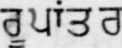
ਰੂਪਾਤਰ
